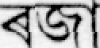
ৰজা
